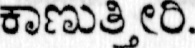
ಕಾಣುತ್ತೀರಿ.
